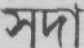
সদা
